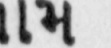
ગામ
